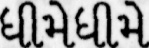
ધીમેધીમે
